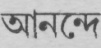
আনন্দে
